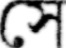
সে
